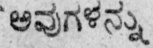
ಅವುಗಳನ್ನು
